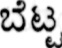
ಬೆಟ್ಟ
